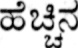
ಹೆಚ್ಚಿನ
